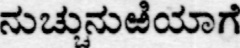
ನುಚ್ಚುನುಱೆಯಾಗೆ
